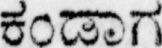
ಕಂಡಾಗ
